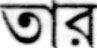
তার
